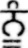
ਨੂੰ
